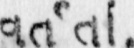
વર્તતાં.
